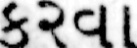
કરવા
